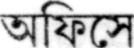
অফিসে
